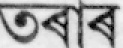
তৰাৰ
